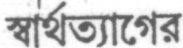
স্বার্থত্যাগের
